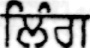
ਲਿੰਗ
